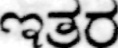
ಇತರ
